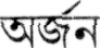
অর্জন
